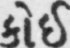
કોઈ
